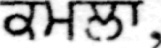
ਕਮਲਾ,
